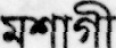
মশাগী
